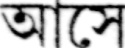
আসে
